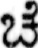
ಚೆ
